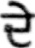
ਦੇ
